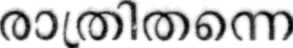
രാത്രിതന്നെ
